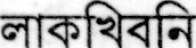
লাকখিবনি
